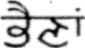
ਭੈਣਾਂ
